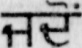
ਜਦੋਂ
